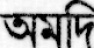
অমদি
